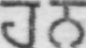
ਹਨ
